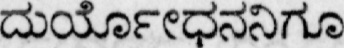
ದುರ್ಯೋಧನನಿಗೂ
